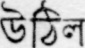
উঠিল
